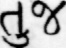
તુજ
